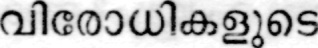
വിരോധികളുടെ
